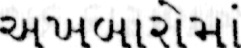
અખબારોમાં
